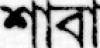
শাবা
